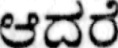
ಆದರೆ
